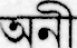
অনী
